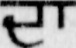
ਦਾ
